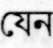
যেন
